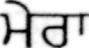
ਮੇਰਾ
